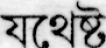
যথেষ্ট
